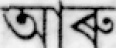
আৰু
